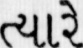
ત્યારે
